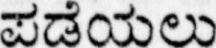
ಪಡೆಯಲು
